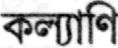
কল্যাণি
